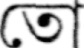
তো
